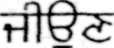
ਜੀਉਣ
